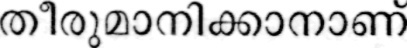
തീരുമാനിക്കാനാണ്
